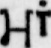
ਮਾਂ
